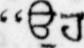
''ਉਹ
